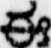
ಈ
